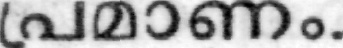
പ്രമാണം.
